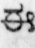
ಈ
